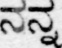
ನನ್ನ
